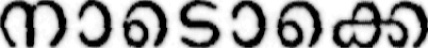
നാടൊക്കെ
